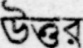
উত্তর
